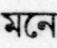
মনে
